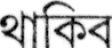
থাকিব
